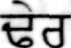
ਢੇਰ
